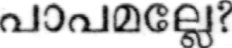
പാപമല്ലേ?
